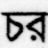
চর
